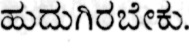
ಹುದುಗಿರಬೇಕು.
